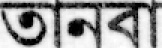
তানবা
